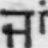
ਜਾਂ
